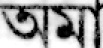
অম
